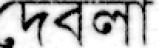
দেবলা
